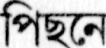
পিছনে
